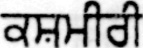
ਕਸ਼ਮੀਰੀ
